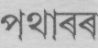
পথাৰৰ
